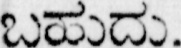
ಬಹುದು.
